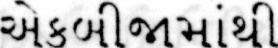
એકબીજામાંથી
